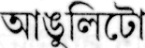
আঙুলিটো
